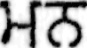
ਮਨ
